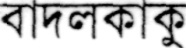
বাদলকাকু
